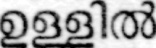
ഉള്ളില്‍
